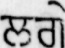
ਲਗੇ
